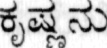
ಕೃಷ್ಣನು
